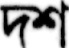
দশ
